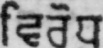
ਵਿਰੋਧ
